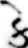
કે
